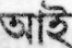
আই
